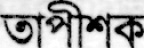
তাপীশক
